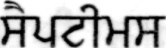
ਸੈਪਟੀਮਸ
